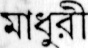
মাধুরী
